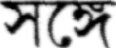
সঙ্গে
